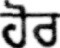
ਹੋਰ
